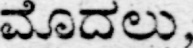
ಮೊದಲು,
